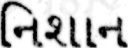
નિશાન
